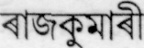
ৰাজকুমাৰী
